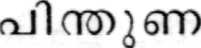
പിന്തുണ
